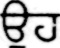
ਉਹ
